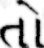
તો
